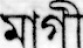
মাগী
